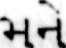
મને
